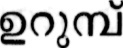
ഉറുമ്പ്
